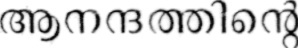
ആനന്ദത്തിന്റെ
